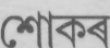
শোকৰ
